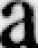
a
